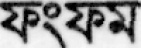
ফংফম
